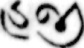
હજી
